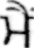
ਮੈਂ
